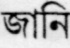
জানি
